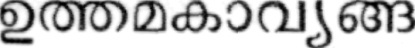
ഉത്തമകാവ്യങ്ങ
